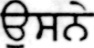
ਉਸਨੇ
